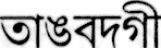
তাঙবদগী
